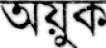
অয়ুক
